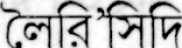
লৈরি’সিদি
